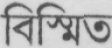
বিস্মিত
